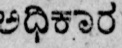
ಅಧಿಕಾರ
